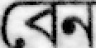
বেন
